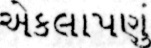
એકલાપણું
